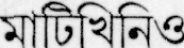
মাটিখিনিও
